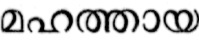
മഹത്തായ
